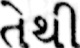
તેથી
